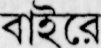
বাইরে
